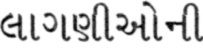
લાગણીઓની
